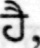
ਹੈ,
